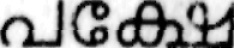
പക്ഷേ
